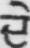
ਦੇ
